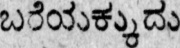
ಬರೆಯಕ್ಕುದು
